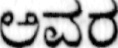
ಅವರ
